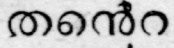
തന്റെ
